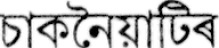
চাকনৈয়াটিৰ
